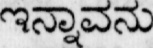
ಇನ್ನಾವನು
